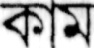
কাম
